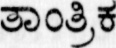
ತಾಂತ್ರಿಕ
